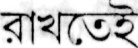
রাখতেই
